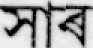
সাৰ
